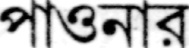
পাওনার
